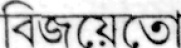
বিজয়েতো
